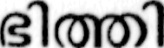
ഭിത്തി
